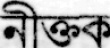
নীক্তক
